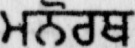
ਮਨੋਰਥ
